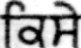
ਕਿਸੇ
